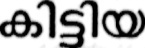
കിട്ടിയ
